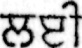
ਲਈ
